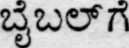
ಬೈಬಲ್ಗೆ
